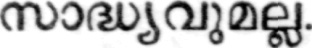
സാദ്ധ്യവുമല്ല.
